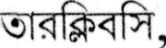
তারক্লিবসি,
